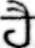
ਹੈ
